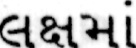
લક્ષમાં
